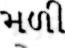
મળી
